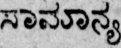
ಸಾಮಾನ್ಯ
